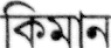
কিমান
